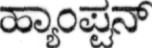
ಹ್ಯಾಂಪ್ಟನ್
